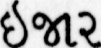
ઇજાર
